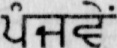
ਪੰਜਵੇਂ
